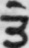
ਤੇ
